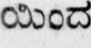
ಯಿಂದ
